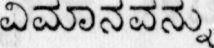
ವಿಮಾನವನ್ನು
